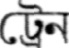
ট্রেন
